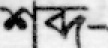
শব্দ-
